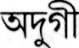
অদুগী
